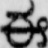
ಈ
